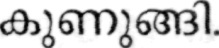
കുണുങ്ങി.
